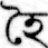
হৈ
